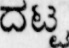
ದಟ್ಟ
